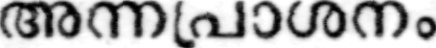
അന്നപ്രാശനം
